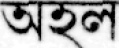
অহল
